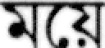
ময়ে
